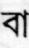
বা
